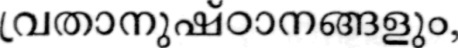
വ്രതാനുഷ്ഠാനങ്ങളും,
